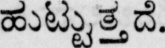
ಹುಟ್ಟುತ್ತದೆ.
